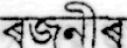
ৰজনীৰ
